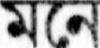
মনে
